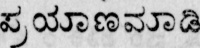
ಪ್ರಯಾಣಮಾಡಿ
